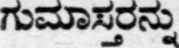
ಗುಮಾಸ್ತರನ್ನು
